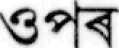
ওপৰ
